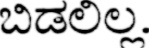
ಬಿಡಲಿಲ್ಲ.
